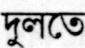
দুলতে
